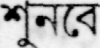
শুনবে
